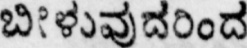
ಬೀಳುವುದರಿಂದ
